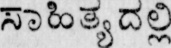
ಸಾಹಿತ್ಯದಲ್ಲಿ
